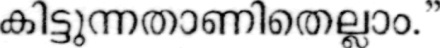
കിട്ടുന്നതാണിതെല്ലാം.”
